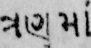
ત્રણમાં
